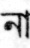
না
